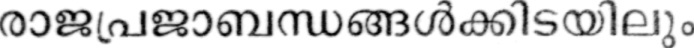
രാജപ്രജാബന്ധങ്ങള്‍ക്കിടയിലും
